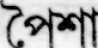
পৈশা
